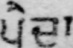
ਪੈਦਾ
